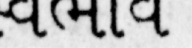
સ્વભાવ
